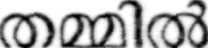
തമ്മില്‍
